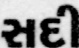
સદી
